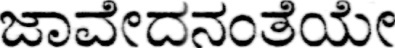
ಜಾವೇದನಂತೆಯೇ
